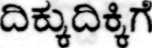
ದಿಕ್ಕುದಿಕ್ಕಿಗೆ
